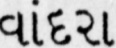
વાંદરા
